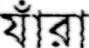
যাঁরা
